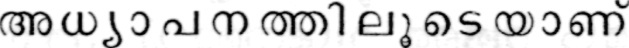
അധ്യാപനത്തിലൂടെയാണ്
